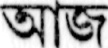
আজ
